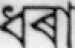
ধৰা
